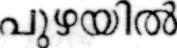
പുഴയില്‍
